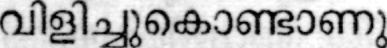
വിളിച്ചുകൊണ്ടാണു
